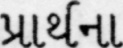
પ્રાર્થના
